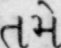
તમે
